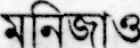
মনিজাও
